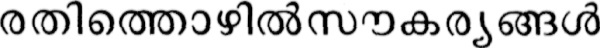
രതിത്തൊഴില്‍സൌകര്യങ്ങള്‍
